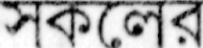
সকলের
